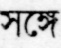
সঙ্গে
